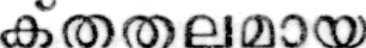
ക്തതലമായ
